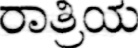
ರಾತ್ರಿಯ
